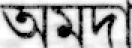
অমদা
